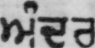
ਅੰਦਰ
